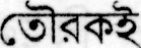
তৌরকই
